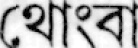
থোংবা
